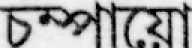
চম্পায়ো
